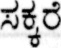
ಸಕ್ಕರೆ
